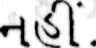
નહીં.
